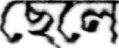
ছেলে
